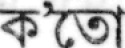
ক'তো
